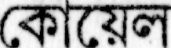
কোয়েল
